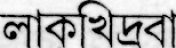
লাকখিদ্রবা
